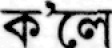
ক'লে
